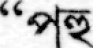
"পহু
